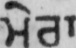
ਮੇਰਾ
